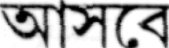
আসবে
